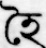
হৈ
